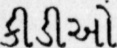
કીડીઓ
